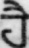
ਹੈ
